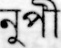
নুপী
